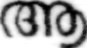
ആ
